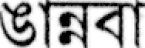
ঙান্নবা
